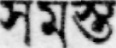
সমস্ত
